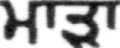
ਮਾੜਾ
